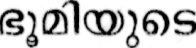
ഭൂമിയുടെ
